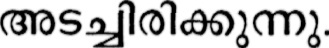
അടച്ചിരിക്കുന്നു.
